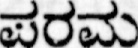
ಪರಮ
